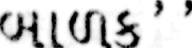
બાળક"
